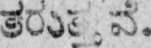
ತರುತ್ತವೆ.
